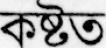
কষ্টত
